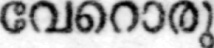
വേറൊരു
